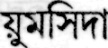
য়ুমসিদা
